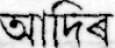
আদিৰ
